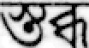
স্তব্ধ
